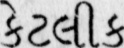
કેટલીક
